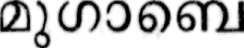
മുഗാബെ
